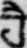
ਹੈ
